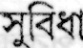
সুবিধা
